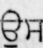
ਉਸ
